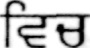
ਵਿਚ
